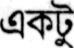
একটু
